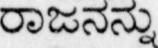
ರಾಜನನ್ನು
